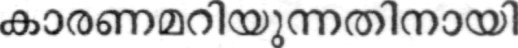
കാരണമറിയുന്നതിനായി
